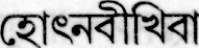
হোৎনবীখিবা
